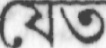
যেত
